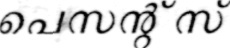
പെസന്റ്സ്
